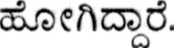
ಹೋಗಿದ್ದಾರೆ.
